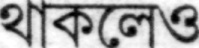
থাকলেও
